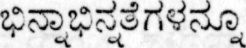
ಭಿನ್ನಾಭಿನ್ನತೆಗಳನ್ನೂ
